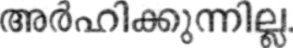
അര്‍ഹിക്കുന്നില്ല.
